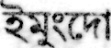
ইমুংদো
